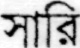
সারি
